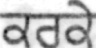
ਕਰਕੇ
